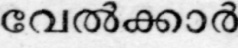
വേല്‍ക്കാര്‍
